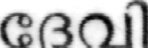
ദേവി
